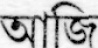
আজি
